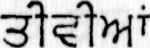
ਤੀਵੀਆਂ
